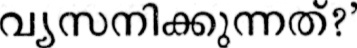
വ്യസനിക്കുന്നത്?’
